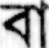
বা
